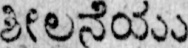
ಶೀಲನೆಯು
